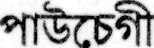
পাউচেগী
